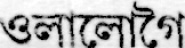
ওলালোগৈ
